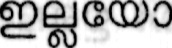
ഇല്ലയോ
